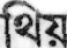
থিয়
